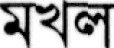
মখল
